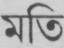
মতি
